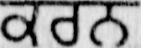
ਕਰਨ
